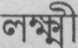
লক্ষ্মী
